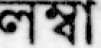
লম্বা
